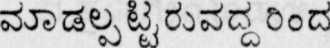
ಮಾಡಲ್ಪಟ್ಟಿರುವದ್ದರಿಂದ
